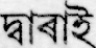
দ্বাৰাই
